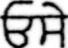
ਓਸੇ
